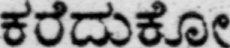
ಕರೆದುಕೋ
